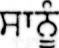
ਸਾਨੂੰ
